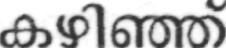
കഴിഞ്ഞ്
